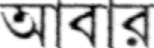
আবার
